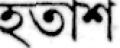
হতাশ
